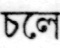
চলে
